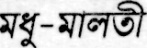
মধু-মালতী
